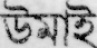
উমাই
